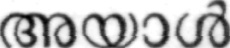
അയാള്‍
